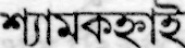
শ্যামকহ্ণাই
